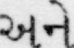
અને
